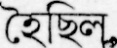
হৈছিল
